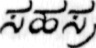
ಸಹಸ್ರ
